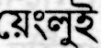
য়েংলুই
